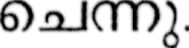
ചെന്നു.
